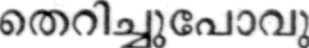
തെറിച്ചുപോവു
